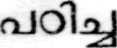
പഠിച്ച
